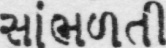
સાંભળતી
